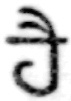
ਹੈ
